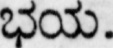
ಭಯ.
